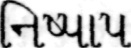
નિષ્પાપ
